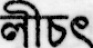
লীচৎ
